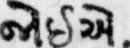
જોઈએ.
